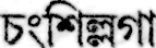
চংশিল্লগা
